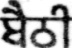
ਬੈਠੀ
